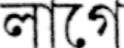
লাগে
